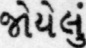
જોયેલું
